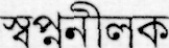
স্বপ্ননীলক
